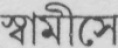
স্বামীসে
